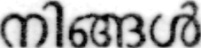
നിങ്ങള്‍
